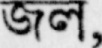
জল,
